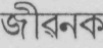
জীৱনক
